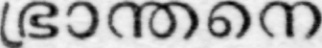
ഭ്രാന്തനെ
